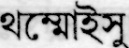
থম্মোইসু
